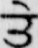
ਤੇ
